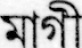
মাগী
